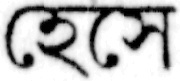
হেসে
